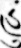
હું
